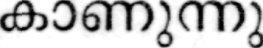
കാണുന്നു
